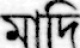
মাদি
